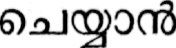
ചെയ്യാന്‍
